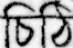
চিঠি
